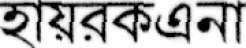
হায়রকএনা
